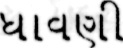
ધાવણી
